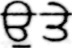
ਉਤੇ
